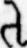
તે
